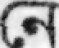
নে
